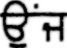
ਉਂਜ
